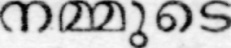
നമ്മുടെ
